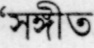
‘সঙ্গীত
